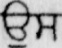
ਉਸ
